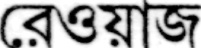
রেওয়াজ
